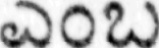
ಎಂಬ
